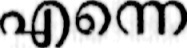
എന്നെ
